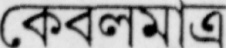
কেবলমাত্র
